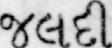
જલદી
